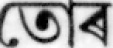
তোৰ
